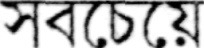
সবচেয়ে
